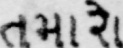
તમારો
